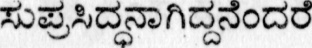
ಸುಪ್ರಸಿದ್ಧನಾಗಿದ್ದನೆಂದರೆ
